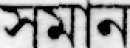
সমান
